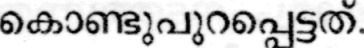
കൊണ്ടുപുറപ്പെട്ടത്.
